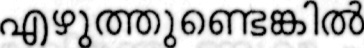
എഴുത്തുണ്ടെങ്കില്‍
